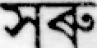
সৰু
